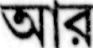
আর
